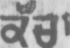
ਕੱਚਾ
